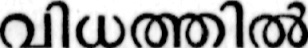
വിധത്തില്‍
